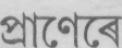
প্রাণেৰে
